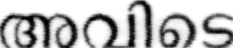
അവിടെ
